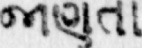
જાણતા
